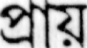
প্রায়
